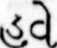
હવે
